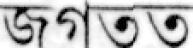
জগতত
